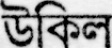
উকিল
